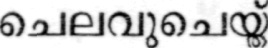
ചെലവുചെയ്ത്
